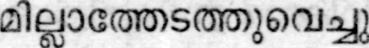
മില്ലാത്തേടത്തുവെച്ചു
